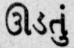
ઊડતું
